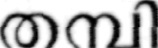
തമ്പി
